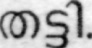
തട്ടി.
